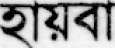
হায়বা
